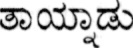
ತಾಯ್ನಾಡು
